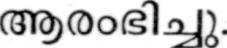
ആരംഭിച്ചു.
